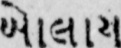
બોલાય
